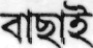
বাছাই
